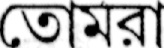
তোমরা
